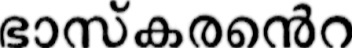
ഭാസ്കരന്റെ
